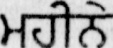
ਮਹੀਨੇ
